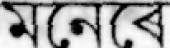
মনেৰে
